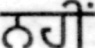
ਨਹੀਂ
